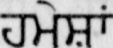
ਹਮੇਸ਼ਾਂ
